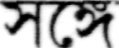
সঙ্গে
